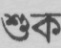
শুক
